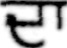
ਦਾ
